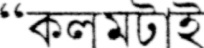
“কলমটাই
